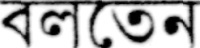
বলতেন
